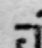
ਹੀ
